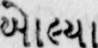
બોલ્યા
